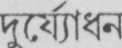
দুৰ্য্যোধন
